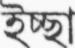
ইচ্ছা
